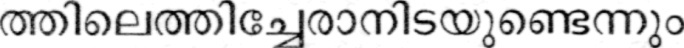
ത്തിലെത്തിച്ചേരാനിടയുണ്ടെന്നും
